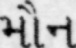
મૌન
